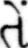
તેં
